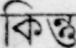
কিন্তু
